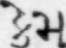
કેમ
